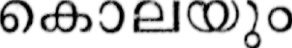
കൊലയും
